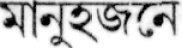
মানুহজনে
